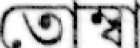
তোম্বা
